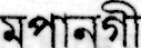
মপানগী
